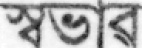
স্বভাৱ
